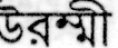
উরম্মী
